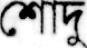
শোদু
